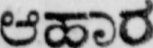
ಆಹಾರ
